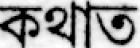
কথাত
